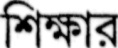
শিক্ষার
